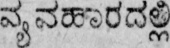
ವ್ಯವಹಾರದಲ್ಲಿ
